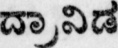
ದ್ರಾವಿಡ
